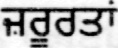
ਜ਼ਰੂਰਤਾਂ
